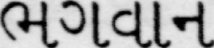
ભગવાન
